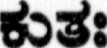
ಕುತಃ
